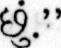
છું."
